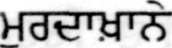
ਮੁਰਦਾਖ਼ਾਨੇ
